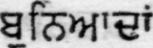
ਬੁਨਿਆਦਾਂ
